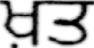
ਖ਼ਤ
